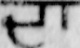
ਦਾ
